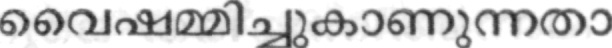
വൈഷമ്മിച്ചുകാണുന്നതാ
